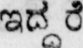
ಇದ್ದರೆ
